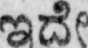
ಇದೇ
